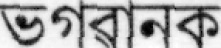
ভগৱানক
